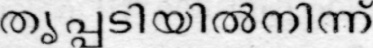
തൃപ്പടിയില്‍നിന്ന്
